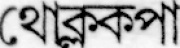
থোক্লকপা
